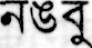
নঙবু
